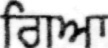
ਗਿਆ
